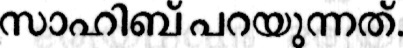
സാഹിബ്പറയുന്നത്.
